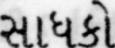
સાધકો
